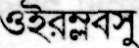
ওইরম্লবসু
